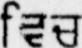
ਵਿਚ
